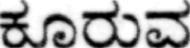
ಕೂರುವ
